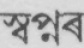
স্বপ্নৰ
